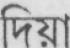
দিয়া
